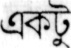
একটু
